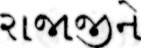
રાજાજીને
